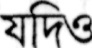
যদিও
